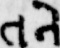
તને
